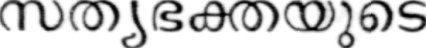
സത്യഭക്തയുടെ
